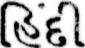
હિંદી
